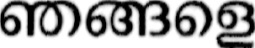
ഞങ്ങളെ
